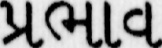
પ્રભાવ
